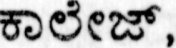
ಕಾಲೇಜ್,
